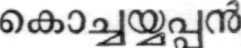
കൊച്ചയ്യപ്പന്‍
